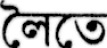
লৈতে
